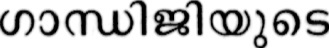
ഗാന്ധിജിയുടെ
